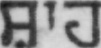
ਸ਼ਾਹ
